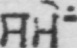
ਸਮੇਂ
